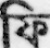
ফি
